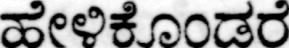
ಹೇಳಿಕೊಂಡರೆ
